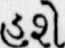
હશે
